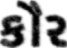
કોર
